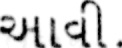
આવી.
